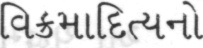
વિક્રમાદિત્યનો
